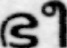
ഭീ
